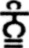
ਨੂੰ
